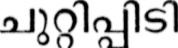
ചുറ്റിപ്പിടി
